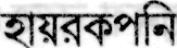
হায়রকপনি
